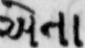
એના
